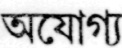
অযোগ্য
